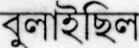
বুলাইছিল
